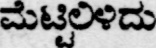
ಮೆಟ್ಟಿಲಿಳಿದು
